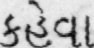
કહેવા
